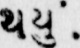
થયું.
